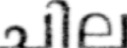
ചില
